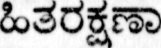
ಹಿತರಕ್ಷಣಾ
